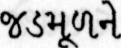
જડમૂળને
